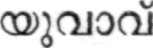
യുവാവ്
